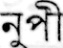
নুপী
